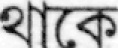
থাকে
